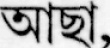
আছা,
